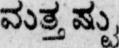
ಮತ್ತಷ್ಟು
